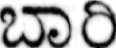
ಬಾರಿ
